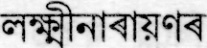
লক্ষ্মীনাৰায়ণৰ
